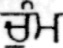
ਚੁੰਮ
